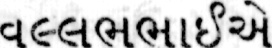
વલ્લભભાઈએ
